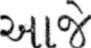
આજે
